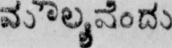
ಮೌಲ್ಯವೆಂದು
